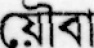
য়ৌবা
